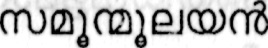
സമൂന്മൂലയന്‍
